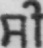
ਸੀ
